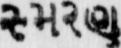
સ્મરણ
